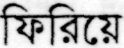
ফিরিয়ে
